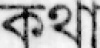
কথা
